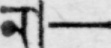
না—
